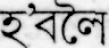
হ'বলৈ
